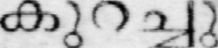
കുറച്ചു
